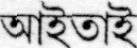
আইতাই
